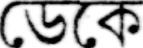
ডেকে
